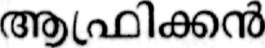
ആഫ്രിക്കന്‍
